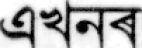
এখনৰ
